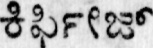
ಕಿರ್ಫೀಜ್
